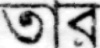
তার
